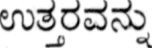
ಉತ್ತರವನ್ನು
